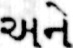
અને
